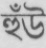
হুঁউ
